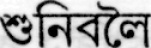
শুনিবলৈ
